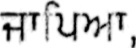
ਜਾਪਿਆ,
